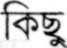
কিছু
